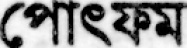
পোৎফম
